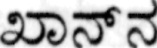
ಖಾನ್ನ
